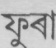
ফুৰা
